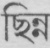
ছিন্ন
